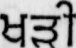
ਖੜੀ
